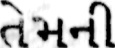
તેમની
